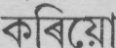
কৰিয়ো
